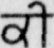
ਕੀ
